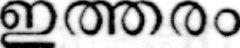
ഇത്തരം
